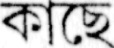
কাছে
